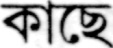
কাছে
